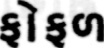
ફોફળ
